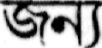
জন্য
